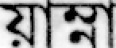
য়াম্না
